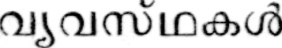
വ്യവസ്ഥകള്‍
